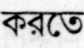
করতে
